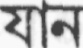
যান
